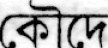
কৌদে
